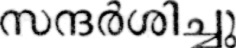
സന്ദര്‍ശിച്ചു
